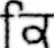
ਕਿ
